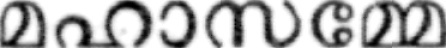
മഹാസമ്മേ
